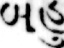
બહુ
